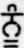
ਨੂੰ
